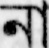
না
